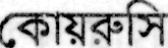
কোয়রুসি
